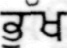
ਭੁੱਖ
